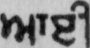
ਆਈ
